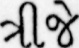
ત્રીજે
